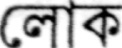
লোক
